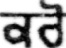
ਕਰੋ
